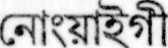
নোংয়াইগী
